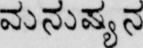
ಮನುಷ್ಯನ
